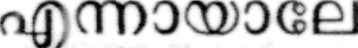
എന്നായാലേ
